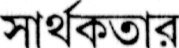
সার্থকতার
